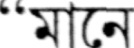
“মানে
